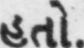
હતો.
